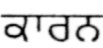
ਕਾਰਨ
